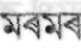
মৰমৰ
